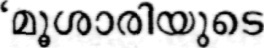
‘മൂശാരിയുടെ
